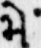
મેં
